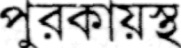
পুরকায়স্থ
